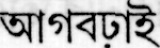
আগবঢ়াই
